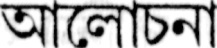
আলোচনা
